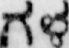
ಗಳ
